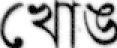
খোঙ
